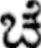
ಚೆ
